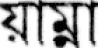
য়াম্না
